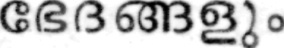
ഭേദങ്ങളും
